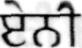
ਏਨੀ
